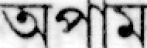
অপাম
